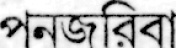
পনজরিবা
